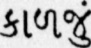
કાળજું
